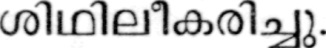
ശീഥിലീകരിച്ചു.
